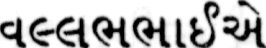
વલ્લભભાઈએ
